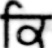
ਕਿ
